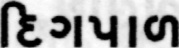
દિગપાળ
